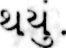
થયું.
